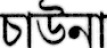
চাউনা
